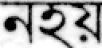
নহয়
